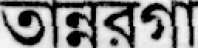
তান্নরগা
